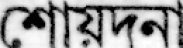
শোয়দনা
